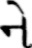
ને
